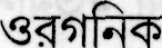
ওরগনিক
